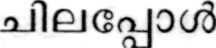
ചിലപ്പോള്‍
